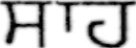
ਸਾਹ
